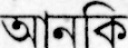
আনকি
